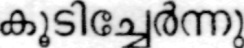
കൂടിച്ചേര്‍ന്നു
